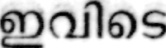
ഇവിടെ
